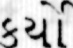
કર્યો
